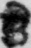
ਤੇ
